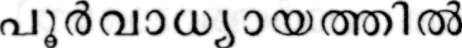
പൂര്‍വാധ്യായത്തില്‍
